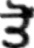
ਤੋਂ
